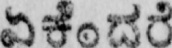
ಏಕೆಂದರೆ
